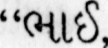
"ભાઈ,
